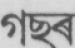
গছৰ
